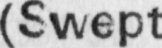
(Swept
